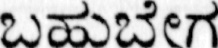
ಬಹುಬೇಗ
